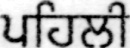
ਪਹਿਲੀ
